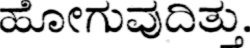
ಹೋಗುವುದಿತ್ತು.
